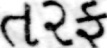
તરફ
